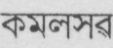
কমলসৱ
